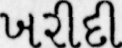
ખરીદી
